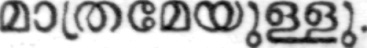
മാത്രമേയുള്ളു.
